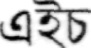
এইচ
